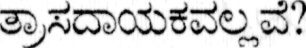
ತ್ರಾಸದಾಯಕವಲ್ಲವೆ?
